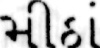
મીઠાં
